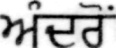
ਅੰਦਰੋਂ
